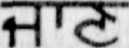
ਜਾਣ
